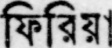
ফিরিয়া
